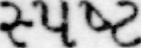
સ્પષ્ટ
